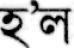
হ'ল
